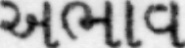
અભાવ
